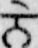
ਨੇ
